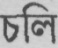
চলি
